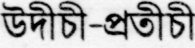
উদীচী-প্রতীচী
